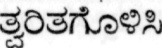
ತ್ವರಿತಗೊಳಿಸಿ
